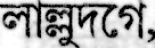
লাল্লুদগে,
